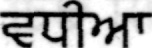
ਵਧੀਆ
